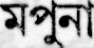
মপুনা
